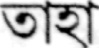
তাহা
